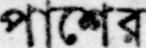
পাশের
